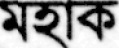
মহাক
